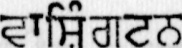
ਵਾਸ਼ਿੰਗਟਨ
